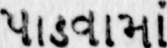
પાડવામાં
